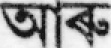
আৰু
